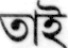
তাই
